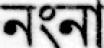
নংনা
